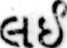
લઈ
